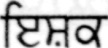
ਇਸ਼ਕ
